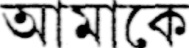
আমাকে
